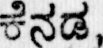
ಕೆನಡ,
